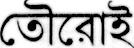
তৌরোই
